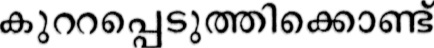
കുററപ്പെടുത്തിക്കൊണ്ട്
